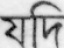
যদি
